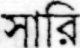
সারি
